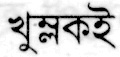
খুম্লকই
